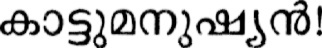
കാട്ടുമനുഷ്യന്‍!
